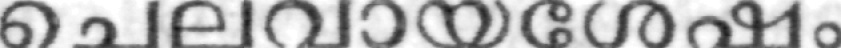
ചെലവായശേഷം
